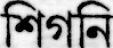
শিগনি
